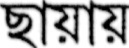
ছায়ায়
